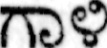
ಗಾಳಿ
